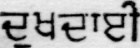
ਦੁਖਦਾਈ
